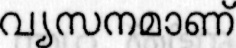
വ്യസനമാണ്
